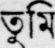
তুমি
